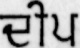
ਦੀਪ
